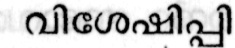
വിശേഷിപ്പി
